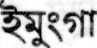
ইমুংগা
